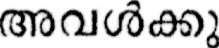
അവള്‍ക്കു
